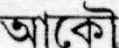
আকৌ
